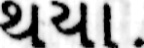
થયા.
